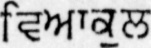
ਵਿਆਕੁਲ
